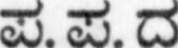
ಪ.ಪ.ದ
